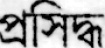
প্রসিদ্ধ
